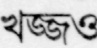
খজ্জও
